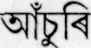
আঁচুৰি
